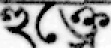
হুক্ত্রে
